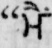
''ਮੈਂ
